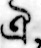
ঐ,
